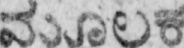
ಮೂಲಕ
